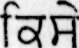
ਕਿਸੇ
